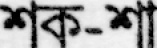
শক-শা
